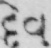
દેવ
